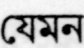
যেমন
